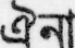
ঐনা
